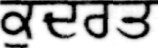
ਕੁਦਰਤ
